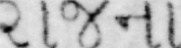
રાજના
